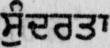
ਸੁੰਦਰਤਾ
